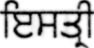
ਇਸਤ੍ਰੀ
